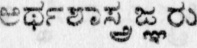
ಅರ್ಥಶಾಸ್ತ್ರಜ್ಞರು
